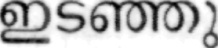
ഇടഞ്ഞു
